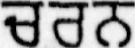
ਚਰਨ
